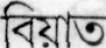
বিয়াত
